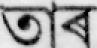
তাৰ
